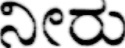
ನೀರು
